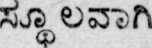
ಸ್ಥೂಲವಾಗಿ
